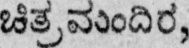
ಚಿತ್ರಮಂದಿರ,
